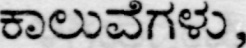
ಕಾಲುವೆಗಳು,
